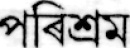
পৰিশ্রম
